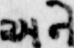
અને
